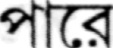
পারে
